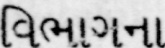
વિભાગના
